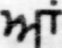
ਆਂ
